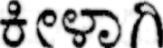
ಕೀಳಾಗಿ
